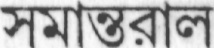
সমান্তরাল
